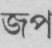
জপ
